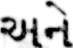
અને
